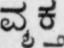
ವ್ಯಕ್ತ
